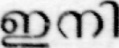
ഇനി
